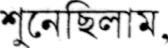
শুনেছিলাম,
